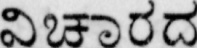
ವಿಚಾರದ
